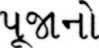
પૂજાનો
